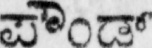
ಪೌಂಡ್
